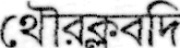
থৌরক্লবদি
